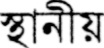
স্থানীয়
